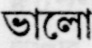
ভালো
